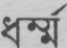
ধৰ্ম্ম
